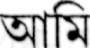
আমি
